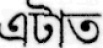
এটাত
